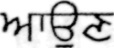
ਆੳਣ
